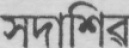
সদাশিৱ
